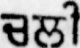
ਚਲੀ
